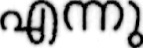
എന്നു
